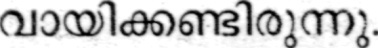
വായിക്കണ്ടിരുന്നു.
